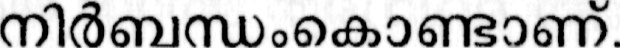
നിര്‍ബന്ധംകൊണ്ടാണ്.
